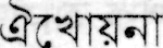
ঐখোয়না
